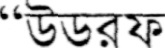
“উডরফ
